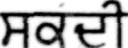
ਸਕਦੀ
